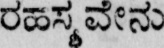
ರಹಸ್ಯವೇನು
